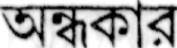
অন্ধকার
